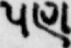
.પણ
